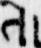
તો
